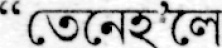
"তেনেহ'লে
